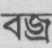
বজ্ৰ
